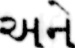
અને
